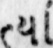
ત્યાં
